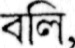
বলি,
